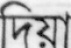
দিয়া
